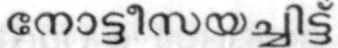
നോട്ടീസയച്ചിട്ട്
